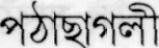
পঠাছাগলী
